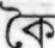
কৈ
